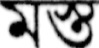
মস্ত
